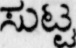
ಸುಟ್ಟ
